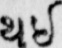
થઈ
